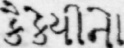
કૈકેયીનો
